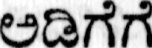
ಅಡಿಗೆಗೆ
